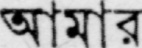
আমার
